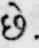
છે.
